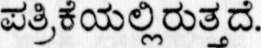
ಪತ್ರಿಕೆಯಲ್ಲಿರುತ್ತದೆ.
